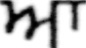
ਆ
